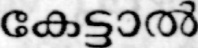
കേട്ടാല്‍
